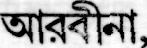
আরবীনা,
